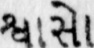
શ્વાસો
